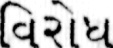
વિરોધ
